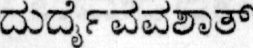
ದುರ್ದೈವವಶಾತ್
